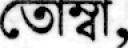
তোম্বা,
